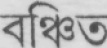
বঞ্চিত
